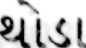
થોડા
